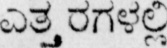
ಎತ್ತರಗಳಲ್ಲಿ
